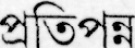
প্রতিপন্ন
